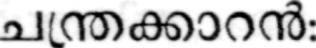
ചന്ത്രക്കാറന്‍:
